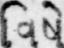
વિષે
